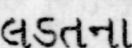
લડતના
